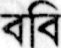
ববি
